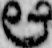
ಆ
